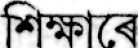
শিক্ষাৰে
